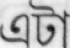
এটা
